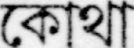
কোথা
